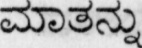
ಮಾತನ್ನು
